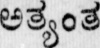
ಅತ್ಯಂತ
